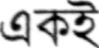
একই
